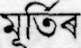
মূর্তিৰ
